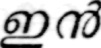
ഇന്‍
